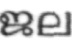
ജല
